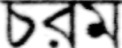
চরম
